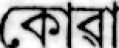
কোৱা
